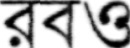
রবও
